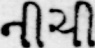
નીચી
